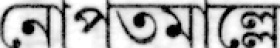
নোপতমাল্লে
